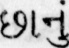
છાનું
